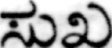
ಸುಖ
